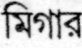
মিগার
